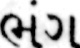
ભંગ
